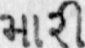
મારી
